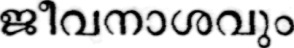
ജീവനാശവും
